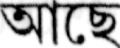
আছে
